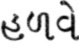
હળવે
